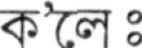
ক'লেঃ
